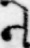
ને
